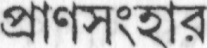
প্রাণসংহার
